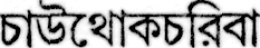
চাউথোচরিবা
